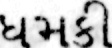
ધમકી
